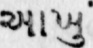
આખું
